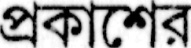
প্রকাশের
